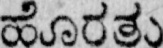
ಹೊರತು
